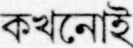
কখনোই
